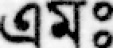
এমঃ
